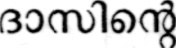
ദാസിന്റെ
